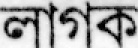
লাগক
